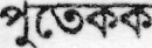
পুতেকক
